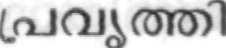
പ്രവൃത്തി
